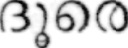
ദൂരെ
